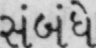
સંબંધે
